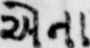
એના
